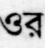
ওর
